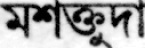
মশক্তুদা
